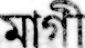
মাগী
